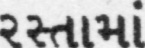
રસ્તામાં
